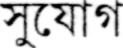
সুযোগ
